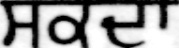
ਸਕਦਾ
